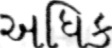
અધિક
